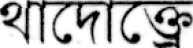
থাদোক্ত্রে
